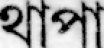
থাপা
